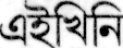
এইখিনি
